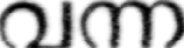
വന്ന
